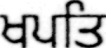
ਖਪਤਿ
